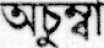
অচুম্বা
